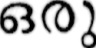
ഒരു
